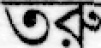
তরু
